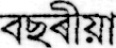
বছৰীয়া
